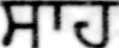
ਸਾਹ
